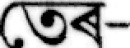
তেৰ-
